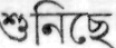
শুনিছে
